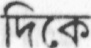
দিকে
